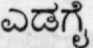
ಎಡಗೈ
